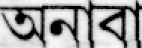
অনাবা
